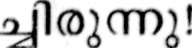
ച്ചിരുന്നു!
